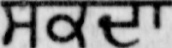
ਸਕਦਾ
